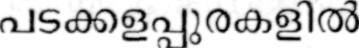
പടക്കളപ്പുരകളില്‍
